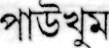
পাউখুম
